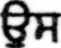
ਉਸ
